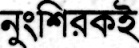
নুংশিরকই
